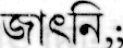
জাৎনি,;
